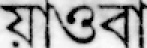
য়াওবা
